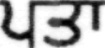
ਪਤਾ
